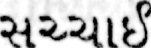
સચ્ચાઈ
